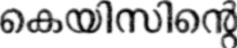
കെയിസിന്റെ
